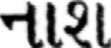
નાશ
